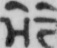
ਮੇਰੇ
